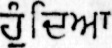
ਹੁੰਦਿਆ
